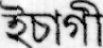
ইচাগী
